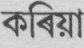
কৰিয়া
